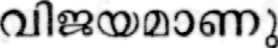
വിജയമാണു
